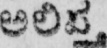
ಅಲಿಪ್ತ
